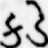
કડે
